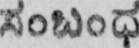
ಸಂಬಂಧ
